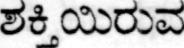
ಶಕ್ತಿಯಿರುವ
